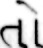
તો
